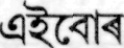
এইবোৰ
